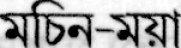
মচিন-ময়া
